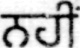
ਨਹੀਂ
